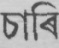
চাৰি
